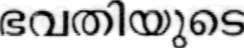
ഭവതിയുടെ
